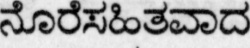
ನೊರೆಸಹಿತವಾದ
